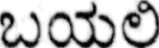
ಬಯಲಿ
